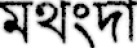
মথংদা
